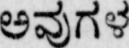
ಅವುಗಳ
